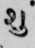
શું
